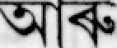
আৰু
